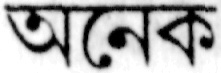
অনেক
